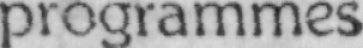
programmes
